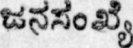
ಜನಸಂಖ್ಯೆ
